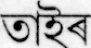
তাইৰ
